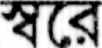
স্বরে
